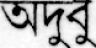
অদুবু
